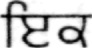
ਇਕ
